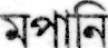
মপানি
